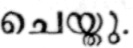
ചെയ്തു.
